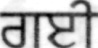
ਗਈ
